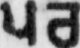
ਪਰ
